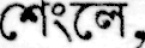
শেংলে,
